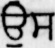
ਉਸ
